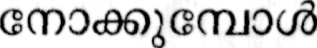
നോക്കുമ്പോള്‍
